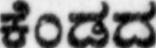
ಕೆಂಡದ
